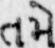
તમે
